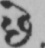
છે.
